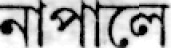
নাপালে
